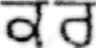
ਕਰ
